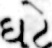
ઘટે
